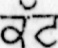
ਕੱਟ
